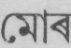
মোৰ
